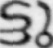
ട്ടു
